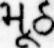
મૂઠ
